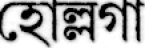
হোল্লগা
